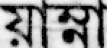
য়াম্না
